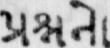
પ્રશ્નનો
